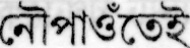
নৌপাওঁতেই
